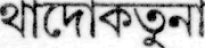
থাদোকতুনা
